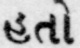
હતો
